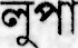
লুপা
